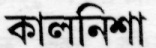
কালনিশা
